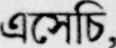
এসেচি,
